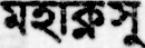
মহাক্নসু
